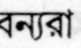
বন্যরা
